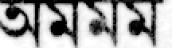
অমমম
